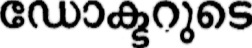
ഡോക്ടറുടെ
